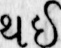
થઈ
